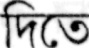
দিতে
